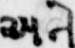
અને
